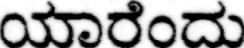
ಯಾರೆಂದು
